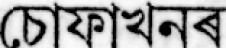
চোফাখনৰ
